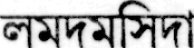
লমদমসিদা
